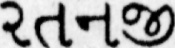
રતનજી
